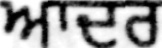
ਆਦਰ
